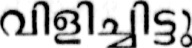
വിളിച്ചിട്ടു
